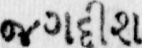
જગદીશ
